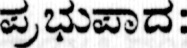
ಪ್ರಭುಪಾದ:
